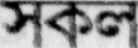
সকল
